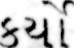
કર્યો
